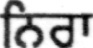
ਨਿਰਾ
